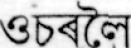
ওচৰলৈ
